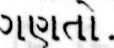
ગણતો.
